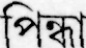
পিন্ধা
